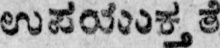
ಉಪಯುಕ್ತತೆ
